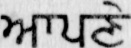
ਆਪਣੇ
